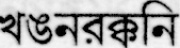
খঙনরক্কনি
